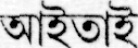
আইতাই
